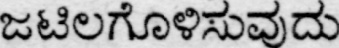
ಜಟಿಲಗೊಳಿಸುವುದು
